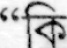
"কি
